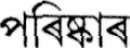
পৰিষ্কাৰ
